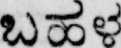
ಬಹಳ
